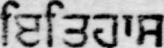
ਇਤਿਹਾਸ
